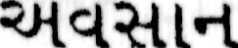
અવસાન
